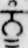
ਨੂੰ
